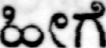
ಹೀಗೆ
